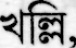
খল্লি,
